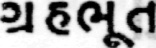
ગ્રહભૂત
